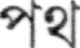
পথ
